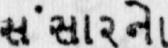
સંસારનો
